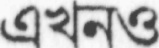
এখনও
